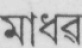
মাধৱ
